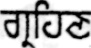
ਗ੍ਰਹਿਣ
